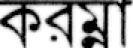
করম্না
